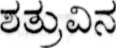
ಶತ್ರುವಿನ
